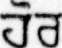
ਹੋਰ
